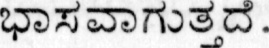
ಭಾಸವಾಗುತ್ತದೆ.
